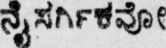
ನೈಸರ್ಗಿಕವೋ
